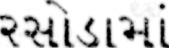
રસોડામાં
